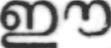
ഈ
